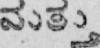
ಮತ್ತು
